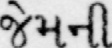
જેમની
